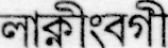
লাক্নীংবগী
